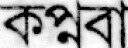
কপ্নবা
